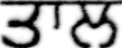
ਤਾਲ
